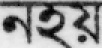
নহয়
